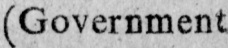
(Government
